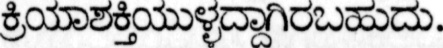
ಕ್ರಿಯಾಶಕ್ತಿಯುಳ್ಳದ್ದಾಗಿರಬಹುದು.
